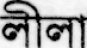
লীলা
